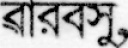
ৱারবসু,
